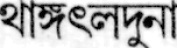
থাঙ্গৎলদুনা
